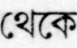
থেকে
